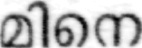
മിനെ
